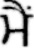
ਮੈਂ
